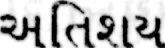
અતિશય
